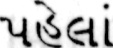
પહેલાં
